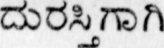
ದುರಸ್ತಿಗಾಗಿ
